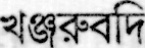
খঞ্জরুবদি
